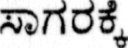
ಸಾಗರಕ್ಕೆ
